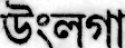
উংলগা
